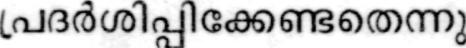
പ്രദര്‍ശിപ്പിക്കേണ്ടതെന്നു
